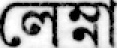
লেম্না
